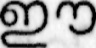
ഈ
